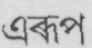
এৰূপ
